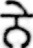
ਨੇ
